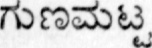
ಗುಣಮಟ್ಟ
